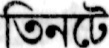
তিনটে
